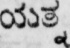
ಯತ್ನ
